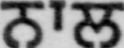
ਨਾਲ
